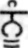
ਨੂੰ
